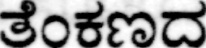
ತೆಂಕಣದ
